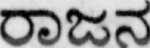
ರಾಜನ
